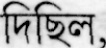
দিছিল,
